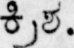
ಕ್ರಿ.ಶ.
